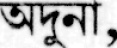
অদুনা,
